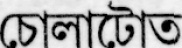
চোলাটোত
